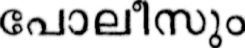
പോലീസും
